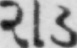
રાડ
